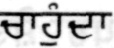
ਚਾਹੁੰਦਾ
